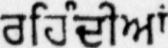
ਰਹਿੰਦੀਆਂ
